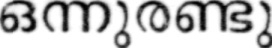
ഒന്നുരണ്ടു
